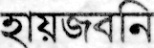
হায়জবনি
